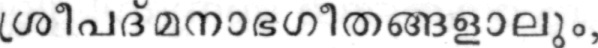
ശ്രീപദ്മനാഭഗീതങ്ങളാലും,
